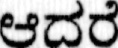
ಆದರೆ
